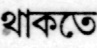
থাকতে
